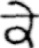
ਕੇ
